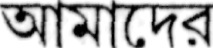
আমাদের
